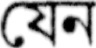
যেন
